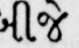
બીજે
